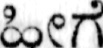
ಹೀಗೆ
